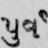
પુર્વ
